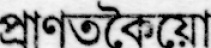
প্রাণতকৈয়ো
